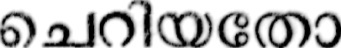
ചെറിയതോ
